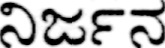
ನಿರ್ಜನ
